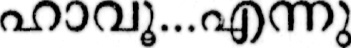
ഹാവൂ...എന്നു
